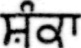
ਸ਼ੰਕਾ
